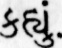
કહ્યું.
